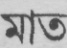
মাত
